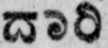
ದಾರಿ
